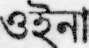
ওইনা
